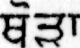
ਥੋੜਾ
